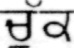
ਚੁੱਕ
